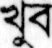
খুব
